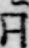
ਸੋ
